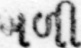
નળી
